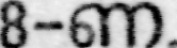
8-ണ.
